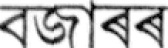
বজাৰৰ
